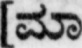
[ಮಾ
